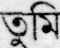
তুমি
